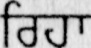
ਰਿਹਾ
